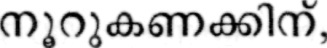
നൂറുകണക്കിന്,
